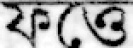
ফত্তে
